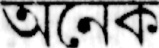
অনেক
